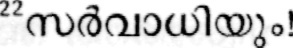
22സര്‍വാധിയും!
